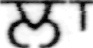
ਲਾ
